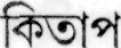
কিতাপ
